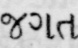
જગત
